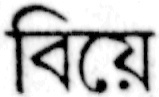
বিয়ে
